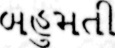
બહુમતી
